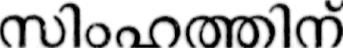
സിംഹത്തിന്
